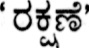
'ರಕ್ಷಣೆ'
